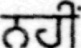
ਨਹੀਂ
